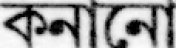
কনানো
